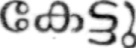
കേട്ടു
